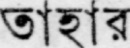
তাহার
